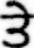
ਤੇ
